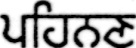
ਪਹਿਨਣ
